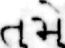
તમે
